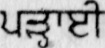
ਪੜ੍ਹਾਈ
